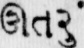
ઊતરું
